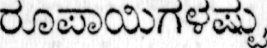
ರೂಪಾಯಿಗಳಷ್ಟು
